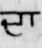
ਦਾ
